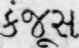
કંજૂસ
